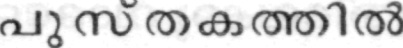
പുസ്തകത്തില്‍
